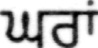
ਘਰਾਂ
